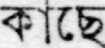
কাছে
